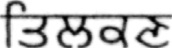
ਤਿਲਕਣ
